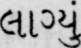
લાગ્યું
